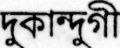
দুকান্দুগী
